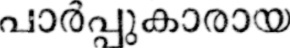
പാര്‍പ്പുകാരായ
